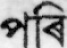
পৰি
